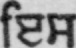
ਇਸ
